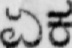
ಏಕ
